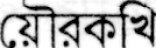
য়ৌরকখি
